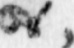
જ,
